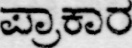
ಪ್ರಾಕಾರ
